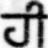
ਹੀ
